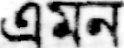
এমন
